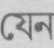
যেন
